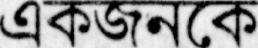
একজনকে
